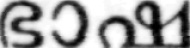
ഭാഷ
